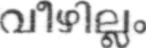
വീഴില്ലം
